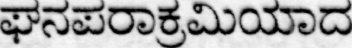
ಘನಪರಾಕ್ರಮಿಯಾದ
